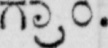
ಗ್ರಾಂ.
